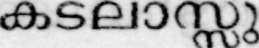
കടലാസ്സു
